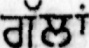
ਗੱਲਾਂ
